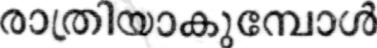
രാത്രിയാകുമ്പോള്‍
